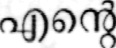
എന്റെ
